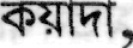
কয়াদা,
